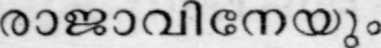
രാജാവിനേയും
